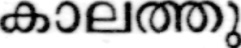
കാലത്തു
